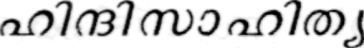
ഹിന്ദിസാഹിത്യ
